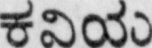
ಕವಿಯ
